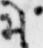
મેં
